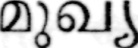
മുഖ്യ
